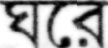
ঘরে
